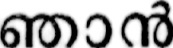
ഞാന്‍
